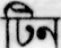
টিন
